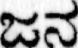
ಜನ
